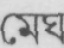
মেঘ
